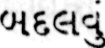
બદલવું
